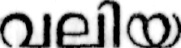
വലിയ
